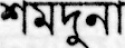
শমদুনা
